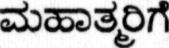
ಮಹಾತ್ಮರಿಗೆ
